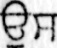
ਉਸ
